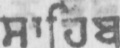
ਸਾਹਿਬ
